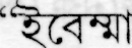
“ইবেম্মা
